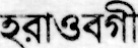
হরাওবগী
